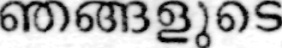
ഞങ്ങളുടെ
